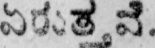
ಏರುತ್ತವೆ.
